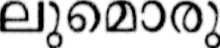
ലുമൊരു
